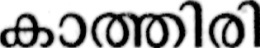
കാത്തിരി
